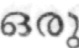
ഒരു
